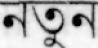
নতুন
